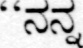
"ನನ್ನ
